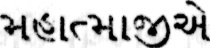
મહાત્માજીએ
